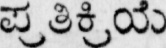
ಪ್ರತಿಕ್ರಿಯೆ
